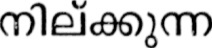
നില്ക്കുന്ന
